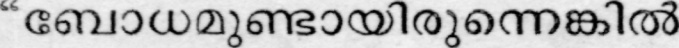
"ബോധമുണ്ടായിരുന്നെങ്കില്‍
